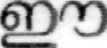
ഈ
